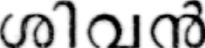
ശിവന്‍
